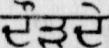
ਦੌੜਦੇ
